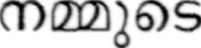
നമ്മുടെ
